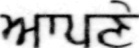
ਆਪਣੇ
